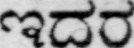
ಇದರ
